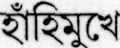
হাঁহিমুখে
